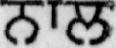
ਨਾਲ
